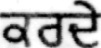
ਕਰਦੇ
